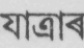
যাত্ৰাৰ
